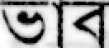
ভাব
